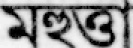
মহুত্তা
